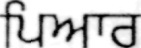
ਪਿਆਰ
